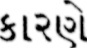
કારણે
